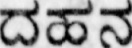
ದಹನ
